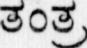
ತಂತ್ರ
